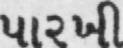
પારખી
